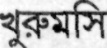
খুরুমসি
